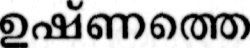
ഉഷ്ണത്തെ
